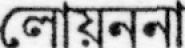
লোয়ননা
